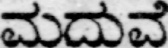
ಮದುವೆ
